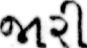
જારી
